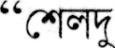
“শেলদু
